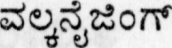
ವಲ್ಕನೈಜಿಂಗ್
